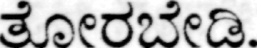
ತೋರಬೇಡಿ.
